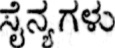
ಸೈನ್ಯಗಳು
